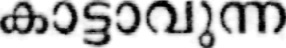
കാട്ടാവുന്ന
